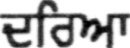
ਦਰਿਆ
